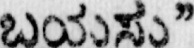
ಬಯಸು”
